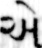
એ
